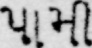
પામી
